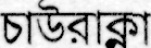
চাউরাক্না
